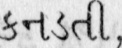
કનડતી,
